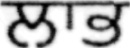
ਲਾਭ
